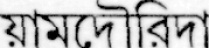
য়ামদৌরিদা
